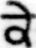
ਕੇ
